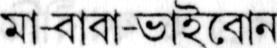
মা-বাবা-ভাইবোন
